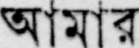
আমার
